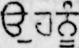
ਉਹਨੂੰ
